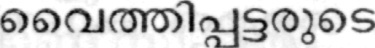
വൈത്തിപ്പട്ടരുടെ
